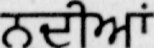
ਨਦੀਆਂ
